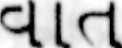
વાત
